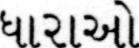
ધારાઓ
